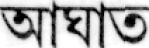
আঘাত
